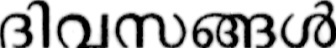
ദിവസങ്ങള്‍
